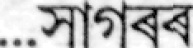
...সাগৰৰ
